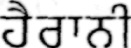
ਹੈਰਾਨੀ
